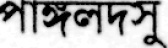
পাঙ্গলদসু
